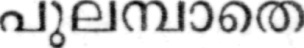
പുലമ്പാതെ
